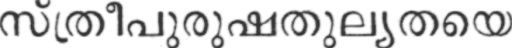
സ്ത്രീപുരുഷതുല്യതയെ
